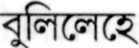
বুলিলেহে
